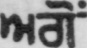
ਅਗੋਂ
